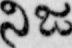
ನಿಜ
